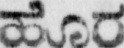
ಹೊರ
